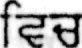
ਵਿਚ
